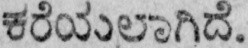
ಕರೆಯಲಾಗಿದೆ.
